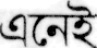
এনেই
